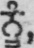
ਨੂੰ,
